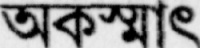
অকস্মাৎ
